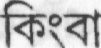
কিংবা
